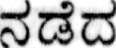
ನಡೆದ
